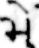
મેં
